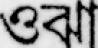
ওঝা
